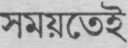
সময়তেই
